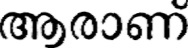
ആരാണ്
